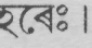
হৰেঃ
